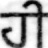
ਹੀ
